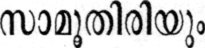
സാമൂതിരിയും
